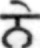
ਨੇ
